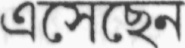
এসেছেন
